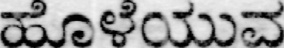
ಹೊಳೆಯುವ
